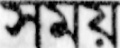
সময়
